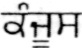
ਕੰਜੂਸ
